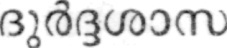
ദുര്‍ദ്ദശാസ
